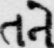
તને
